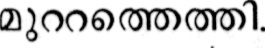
മുററത്തെത്തി.
